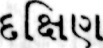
દક્ષિણ
